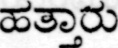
ಹತ್ತಾರು
